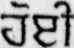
ਹੋਈ
